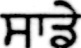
ਸਾਡੇ
